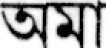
অমা
